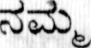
ನಮ್ಮ
